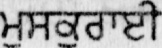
ਮੁਸਕੁਰਾਈ
